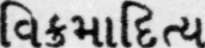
વિક્રમાદિત્ય
